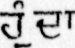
ਹੁੰਦਾ
